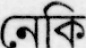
নেকি
